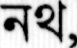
নথ,
